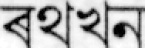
ৰথখন
